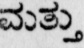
ಮತ್ತು
